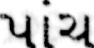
પાંચ
